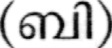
(ബി)
